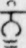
ਨੂੰ
